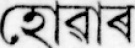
হোৱাৰ
